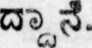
ದ್ದಾನೆ.
